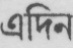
এদিন
